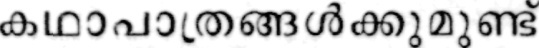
കഥാപാത്രങ്ങള്‍ക്കുമുണ്ട്
